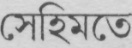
সেহিমতে
